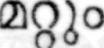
മറ്റും
